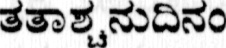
ತತಾಶ್ಚನುದಿನಂ
